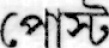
পোস্ট
